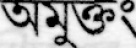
অমুক্তং
